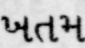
ખતમ
